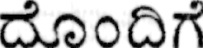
ದೊಂದಿಗೆ
